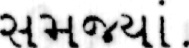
સમજ્યાં.
